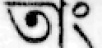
তাং
